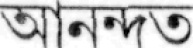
আনন্দত
